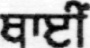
ਥਾਈਂ
